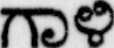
ಗಾಳಿ
